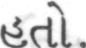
હતો.
